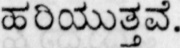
ಹರಿಯುತ್ತವೆ.
